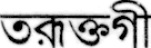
তরূক্তগী
